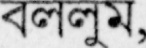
বললুম,
